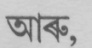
আৰু,
